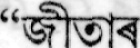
"জীতাৰ
